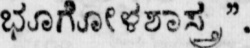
ಭೂಗೋಳಶಾಸ್ತ್ರ”
